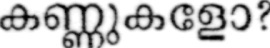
കണ്ണുകളോ?
